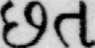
છત
